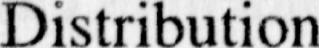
Distribution
